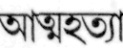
আত্মহত্যা
